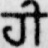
ਹੀ
